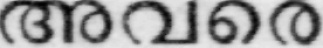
അവരെ
